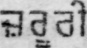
ਜ਼ਰੂਰੀ
